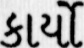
કાર્યો
